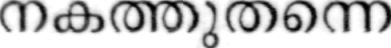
നകത്തുതന്നെ
